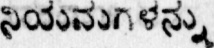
ನಿಯಮಗಳನ್ನು
